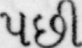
પછી
